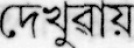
দেখুৱায়
